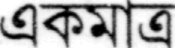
একমাত্র
